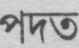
পদত
